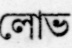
লোভ
